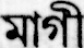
মাগী
